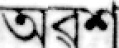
অৱশ
